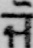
ਜੋ
